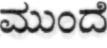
ಮುಂದೆ
